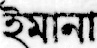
ইমানা
